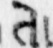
તો
